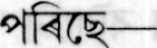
পৰিছে-
